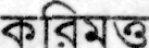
করিমত্ত
